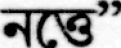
নত্তে”
